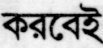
করবেই
